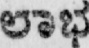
ಲಾಭ
